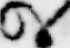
જ
